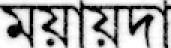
ময়ায়দা
